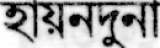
হায়নদুনা
